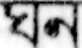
ঘন
